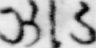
ઝાડ
